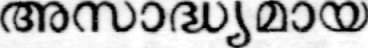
അസാദ്ധ്യമായ
